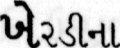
ખેરડીના
